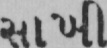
સાખી
